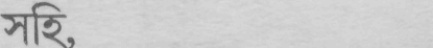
সহি,
